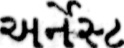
અર્નેસ્ટ
